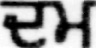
ਦਮ
